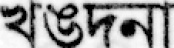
খঙদনা
